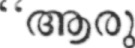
"ആരു
